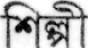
শিল্পী
